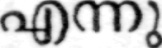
എന്നു
